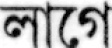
লাগে
